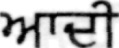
ਆਦੀ
